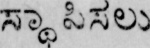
ಸ್ಥಾಪಿಸಲು
